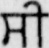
ਸੀ
